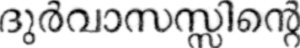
ദുര്‍വാസസ്സിന്റെ
